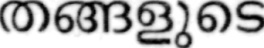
തങ്ങളുടെ
